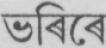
ভৰিৰে
